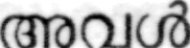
അവള്‍
